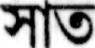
সাত
